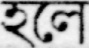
হলে
